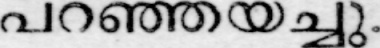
പറഞ്ഞയച്ചു.
